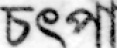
চৎপা
